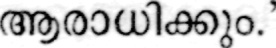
ആരാധിക്കും.’
